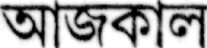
আজকাল
